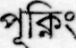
পূক্নিং
